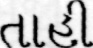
તાહી
